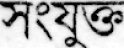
সংযুক্ত
